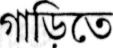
গাড়িতে
